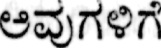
ಅವುಗಳಿಗೆ
